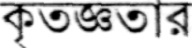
কৃতজ্ঞতার
